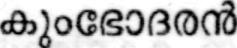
കുംഭോദരന്‍
